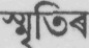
স্মৃতিৰ
